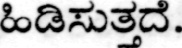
ಹಿಡಿಸುತ್ತದೆ.
